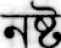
নষ্ট
